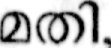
മതി,
